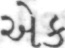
એક
